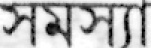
সমস্যা
